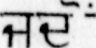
ਜਦੋਂ
